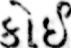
કોઈ
